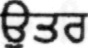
ਉਤਰ
